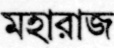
মহারাজ
